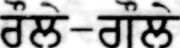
ਰੌਲੇ-ਗੌਲੇ
